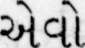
એવો
